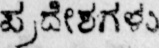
ಪ್ರದೇಶಗಳು
